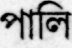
পালি
